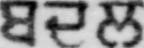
ਬਦਲ
